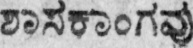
ಶಾಸಕಾಂಗವು
